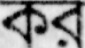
কর
